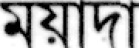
ময়াদা
